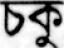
চকু
